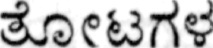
ತೋಟಗಳ
